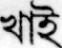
খাই
